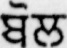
ਬੋਲ
